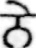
ਨੇ
